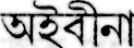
অইবীনা
